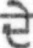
ਦੇ
